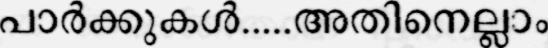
പാര്‍ക്കുകള്‍.....അതിനെല്ലാം
